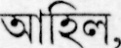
আহিল,
